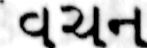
વચન
